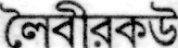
লৈবীরকউ
